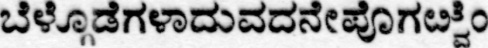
ಬೆಳ್ಗೊಡೆಗಳಾದುವದನೇಪೊಗೞ್ವಂ
